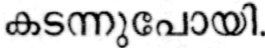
കടന്നുപോയി.
